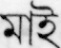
মাই
